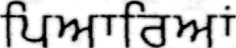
ਪਿਆਰਿਆਂ
